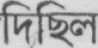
দিছিল
